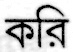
করি
